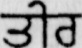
ਤੀਰ
